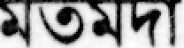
মতমদা
